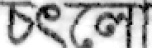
চৎলো
